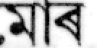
মোৰ
